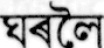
ঘৰলৈ
